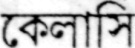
কেলাসি
